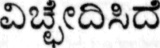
ವಿಚ್ಛೇದಿಸಿದೆ
